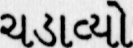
ચડાવ્યો
